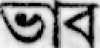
ভাব
